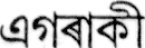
এগৰাকী
